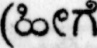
(ಹೀಗೆ
